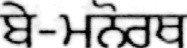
ਬੇ-ਮਨੋਰਥ
